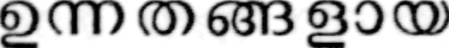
ഉന്നതങ്ങളായ
